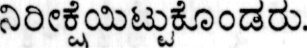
ನಿರೀಕ್ಷೆಯಿಟ್ಟುಕೊಂಡರು.
